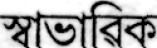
স্বাভাৱিক
